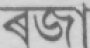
ৰজা
